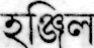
হঞ্জিল
